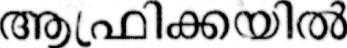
ആഫ്രിക്കയില്‍
